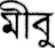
মীবু
